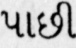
પાછી
